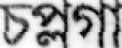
চপ্লগা
